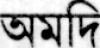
অমদি
